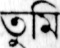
তুমি
